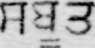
ਸਬੂਤ
